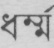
ধৰ্ম্ম
